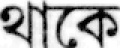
থাকে
